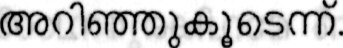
അറിഞ്ഞുകൂടെന്ന്.
